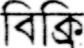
বিক্রি
